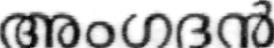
അംഗദന്‍
